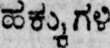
ಹಕ್ಕುಗಳಿ
